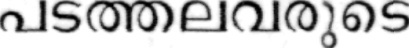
പടത്തലവരുടെ
